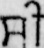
ਸੀ
